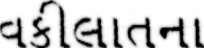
વકીલાતના
